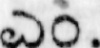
ಎಂ.
